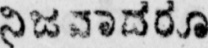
ನಿಜವಾದರೂ
